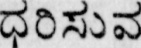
ಧರಿಸುವ
